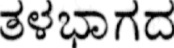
ತಳಭಾಗದ
